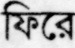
ফিরে
